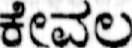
ಕೇವಲ
